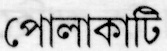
পোলাকাটি
